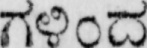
ಗಳಿಂದ
